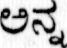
ಅನ್ನ
